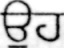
ਉਹ
